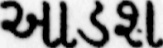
આડશ
